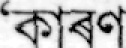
'কাৰণ
